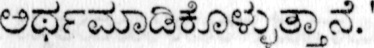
ಅರ್ಥಮಾಡಿಕೊಳ್ಳುತ್ತಾನೆ.
